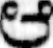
ಆ
